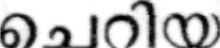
ചെറിയ
